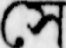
সে
